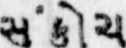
સંકોચ
